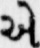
એ
